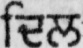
ਦਿਲ
